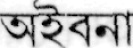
অইবনা
